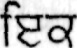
ਇਕ
